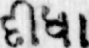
દીધા
